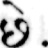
છે.
